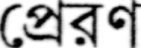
প্রেরণ
